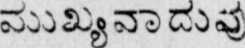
ಮುಖ್ಯವಾದುವು
